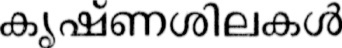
കൃഷ്ണശിലകള്‍
